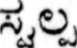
ಸ್ವಲ್ಪ
